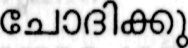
ചോദിക്കു
